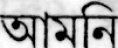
আমনি
